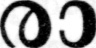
രാ
